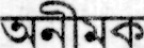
অনীমক
